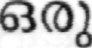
ഒരു
